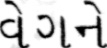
વેગને
